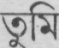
তুমি
